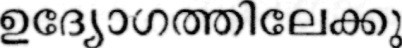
ഉദ്യോഗത്തിലേക്കു
